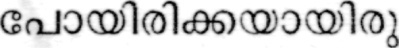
പോയിരിക്കയായിരു
